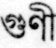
গুণী
